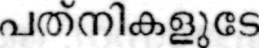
പത്നികളുടേ
